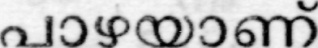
പാഴയാണ്
